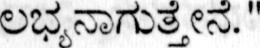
ಲಭ್ಯನಾಗುತ್ತೇನೆ.”
